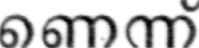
ണെന്ന്
